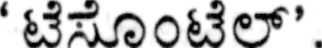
'ಟೆಸೊಂಟೆಲ್'
